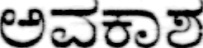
ಅವಕಾಶ
